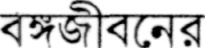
বঙ্গজীবনের
